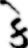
કે
